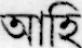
আহি
